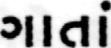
ગાતાં
